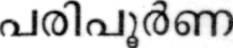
പരിപൂര്‍ണ
